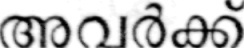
അവര്‍ക്ക്
